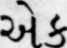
એક
